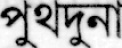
পুথদুনা
